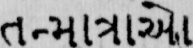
તન્માત્રાઓ
